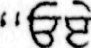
''ਓਏ
